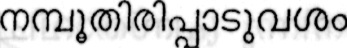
നമ്പൂതിരിപ്പാടുവശം
